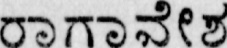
ರಾಗಾವೇಶ
